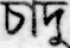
চাদু
